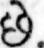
છે.
